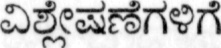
ವಿಶ್ಲೇಷಣೆಗಳಿಗೆ
